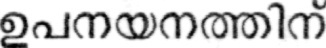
ഉപനയനത്തിന്
